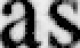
as
